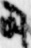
બે
